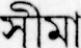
সীমা
